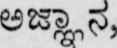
ಅಜ್ಞಾನ,
